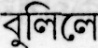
বুলিলে
